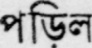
পড়িল
